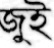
জুই
